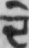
ਦੇ
